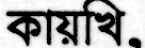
কায়খি,
